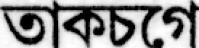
তাকচগে
